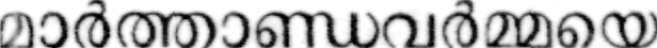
മാര്‍ത്താണ്ഡവര്‍മ്മയെ
